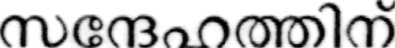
സന്ദേഹത്തിന്
